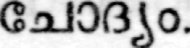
ചോദ്യം.
